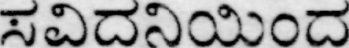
ಸವಿದನಿಯಿಂದ
